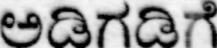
ಅಡಿಗಡಿಗೆ
